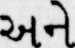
અને
